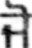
ਜੋ
